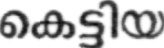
കെട്ടിയ
